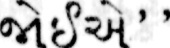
જોઈએ"
